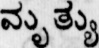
ಮೃತ್ಯು
